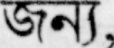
জন্য,
